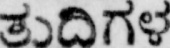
ತುದಿಗಳ
